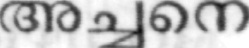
അച്ചനെ
